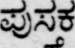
ಪುಸ್ತಕ
